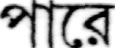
পারে
